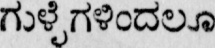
ಗುಳ್ಳೆಗಳಿಂದಲೂ
